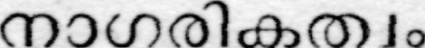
നാഗരികത്വം
